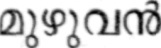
മുഴുവന്‍
